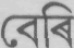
বেৰি
